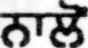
ਨਾਲੋਂ
